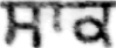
ਸਾਕ
